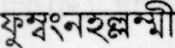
ফুম্বংনহল্লম্মী
